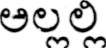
ಅಲ್ಲಲ್ಲಿ
